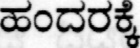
ಹಂದರಕ್ಕೆ
